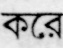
করে
